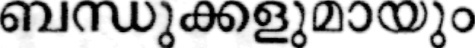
ബന്ധുക്കളുമായും
